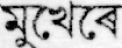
মুখেৰে
